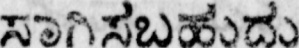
ಸಾಗಿಸಬಹುದು
